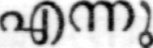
എന്നു
